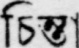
চিন্তা
